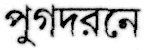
পুগদরনে
